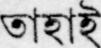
তাহাই
